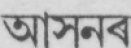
আসনৰ
